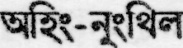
অহিং-নুংথিল
